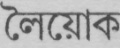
লৈয়োক
